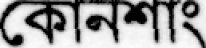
কোনশাং
